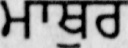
ਮਾਥੁਰ
